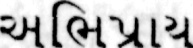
અભિપ્રાય
